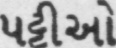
પટ્ટીઓ
